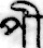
পী
